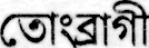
তোংব্রাগী
